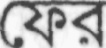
ফের
